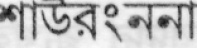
শাউরংননা
